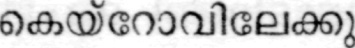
കെയ്റോവിലേക്കു
